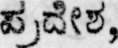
ಪ್ರದೇಶ,
